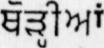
ਥੋੜ੍ਹੀਆਂ
